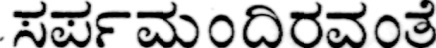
ಸರ್ಪಮಂದಿರವಂತೆ
